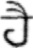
ਹੈ
